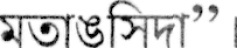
মতাঙসিদা”।
